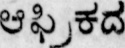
ಆಫ್ರಿಕದ
